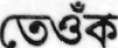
তেওঁক
